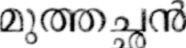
മുത്തച്ഛന്‍
